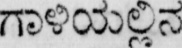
ಗಾಳಿಯಲ್ಲಿನ
